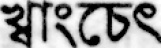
খ্বাংচেৎ
